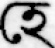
হে
